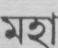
মহা
